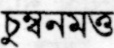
চুম্বনমত্ত
